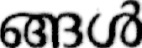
ങ്ങള്‍
